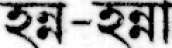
হন্ন-হন্না
